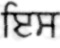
ਇਸ
